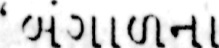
'બંગાળના
